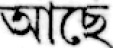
আছে
